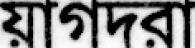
য়াগদরা
